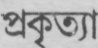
প্ৰকৃত্যা
